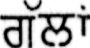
ਗੱਲਾਂ
